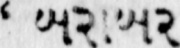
'બરાબર
